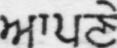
ਆਪਣੇ
